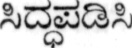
ಸಿದ್ಧಪಡಿಸಿ
